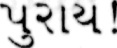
પુરાય!
